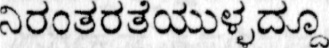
ನಿರಂತರತೆಯುಳ್ಳದ್ದೂ
